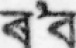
ৰ'ব
